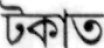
টকাত
